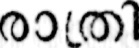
രാത്രി
